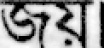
জয়।
